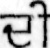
ਦੀ
